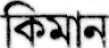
কিমান
